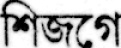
শিজগে
